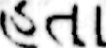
હતા
